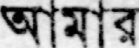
আমার
